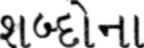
શબ્દોના
